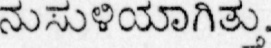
ನುಸುಳಿಯಾಗಿತ್ತು.
